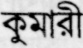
কুমারী
